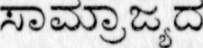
ಸಾಮ್ರಾಜ್ಯದ
